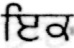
ਇਕ
